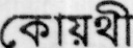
কোয়থী
